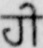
ਹੀ
